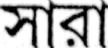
সারা
